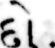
દો.
